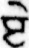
ਏ
